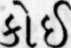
કોઈ
